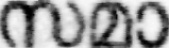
സമാ
